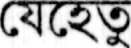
যেহেতু
